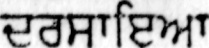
ਦਰਸਾਇਆ
